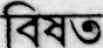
বিষত
